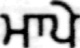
ਮਾਪੇ
